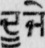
ਦੂਜੇ
